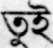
তুই
